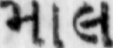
માલ
